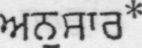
ਅਨੁਸਾਰ*
